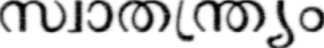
സ്വാതന്ത്ര്യം
